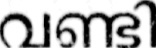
വണ്ടി
